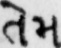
તેમ
